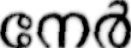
നേര്‍
